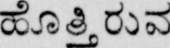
ಹೊತ್ತಿರುವ
